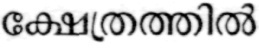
ക്ഷേത്രത്തില്‍
